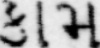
કામ
